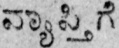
ವ್ಯಾಪ್ತಿಗೇ
